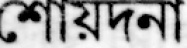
শোয়দনা
